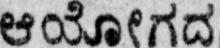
ಆಯೋಗದ
